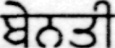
ਬੇਨਤੀ
